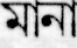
মানা
